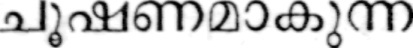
ചൂഷണമാകുന്ന
